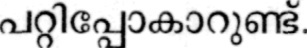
പറ്റിപ്പോകാറുണ്ട്.
